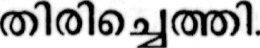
തിരിച്ചെത്തി.
